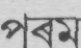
পৰম
